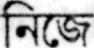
নিজে
